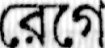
রেগে
